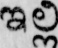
ಇಲ್ಲಿ
